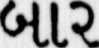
બાર
